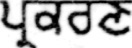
ਪ੍ਰਕਰਣ
